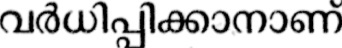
വര്‍ധിപ്പിക്കാനാണ്
